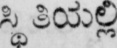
ಸ್ಥಿತಿಯಲ್ಲಿ
